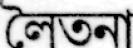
লৈতনা
